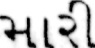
મારી
